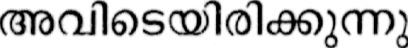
അവിടെയിരിക്കുന്നു
